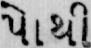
પોથી
